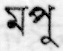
মপু
